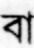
বা
